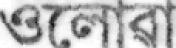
ওলোৱা
